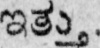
ಇತ್ತು.
